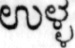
ಉಳ್ಳ
